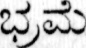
ಭ್ರಮೆ
